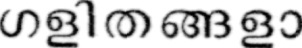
ഗളിതങ്ങളാ
